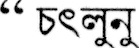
“চৎলুনু
